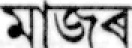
মাজৰ
